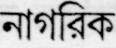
নাগরিক
